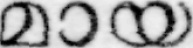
മായ
